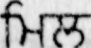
ਮਿਲ
